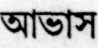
আভাস
